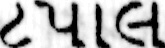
ટપાલ
